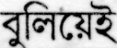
বুলিয়েই
